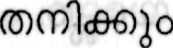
തനിക്കും
